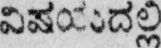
ವಿಷಯದಲ್ಲಿ
